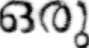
ഒരു
